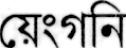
য়েংগনি
